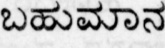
ಬಹುಮಾನ
